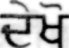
ਦੇਖੋ
